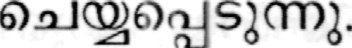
ചെയ്യപ്പെടുന്നു.
